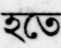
হতে
